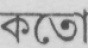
কতো
